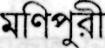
মণিপুরী
